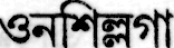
ওনশিল্লগা
